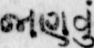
જાણવું
